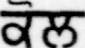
ਕੋਲ
